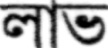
লাভ
